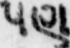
પણ
